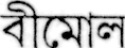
বীমোল
